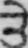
ਤੇ
